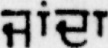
ਜਾਂਦਾ
